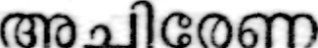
അചിരേണ
